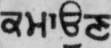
ਕਮਾਉਣ
